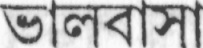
ভালবাসা
